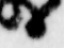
જ
